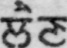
ਲੈਣ
